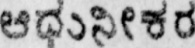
ಆಧುನೀಕರ
